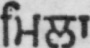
ਮਿਲਾ
